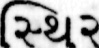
સ્થિર
